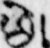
છો
